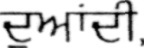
ਦੁਆਂਦੀ,
